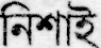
নিশাই
